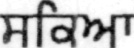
ਸਕਿਆ
